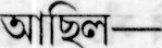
আছিল-
